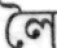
লৈ
